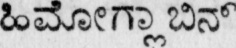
ಹಿಮೋಗ್ಲಾಬಿನ್
